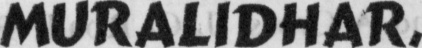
MURALIDHAR,
